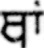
ਥਾਂ
